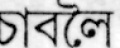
চাবলৈ
